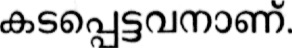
കടപ്പെട്ടവനാണ്.
